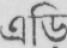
এড়ি
